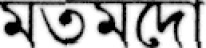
মতমদো
